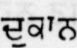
ਦੁਕਾਨ
